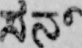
ಸನ್
